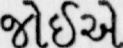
જોઈએ
